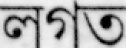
লগত
